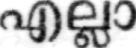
എല്ലാ
